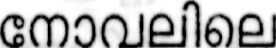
നോവലിലെ
